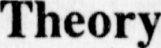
Theory
